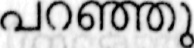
പറഞ്ഞു
